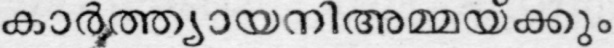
കാര്‍ത്ത്യായനിഅമ്മയ്ക്കും
